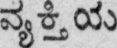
ವ್ಯಕ್ತಿಯ
